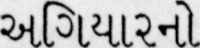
અગિયારનો
